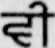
ਵੀ
